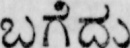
ಬಗೆದು
